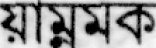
য়াম্নমক
